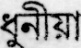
ধুনীয়া
